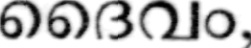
ദൈവം,
